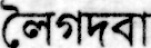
লৈগদবা
